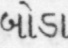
બોડો
